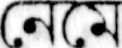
নেমে
